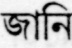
জানি
